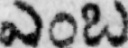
ಎಂಬ
